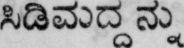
ಸಿಡಿಮದ್ದನ್ನು
